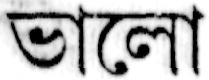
ভালো
